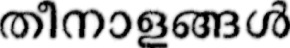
തീനാളങ്ങള്‍
